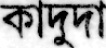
কাদুদা
